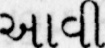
આવી
